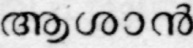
ആശാന്‍
